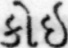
કોઈ
